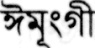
ঈমূংগী
